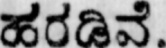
ಹರಡಿವೆ.
